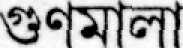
গুণমালা
